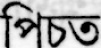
পিচত
